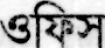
ওফিস
